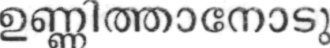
ഉണ്ണിത്താനോടു
